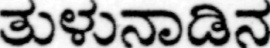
ತುಳುನಾಡಿನ
